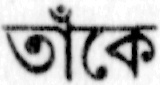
তাঁকে
